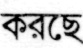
করছে
